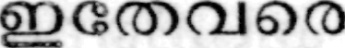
ഇതേവരെ
